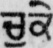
ਚੁਕੇ
